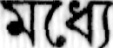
মধ্যে
